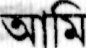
আমি
